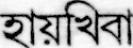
হায়খিবা
